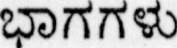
ಭಾಗಗಳು
